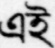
এই
